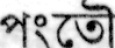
পংতৌ
